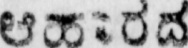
ಆಹಾರದ
